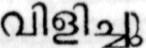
വിളിച്ചു
